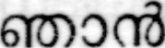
ഞാന്‍
